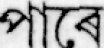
পাৰে
